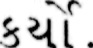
કર્યોં.
